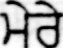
ਮੇਰੇ
